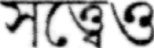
সত্ত্বেও
